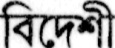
বিদেশী
